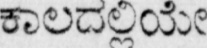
ಕಾಲದಲ್ಲಿಯೇ
